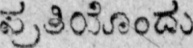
ಪ್ರತಿಯೊಂದು
